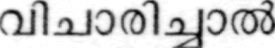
വിചാരിച്ചാല്‍
